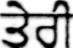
ਤੇਰੀ
